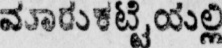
ಮಾರುಕಟ್ಟೆಯಲ್ಲಿ
